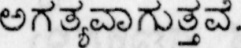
ಅಗತ್ಯವಾಗುತ್ತವೆ.
